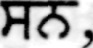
ਸਨ,
